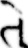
તે
